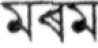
মৰম
